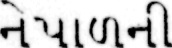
નેપાળની
